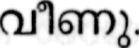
വീണു.
